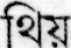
থিয়
